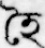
হৈ
